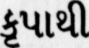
કૃપાથી
